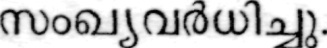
സംഖ്യവര്‍ധിച്ചു.
